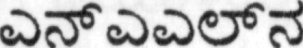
ಎನ್‌ಎಎಲ್‌ನ
